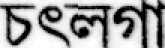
চৎলগা
